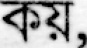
কয়,
